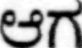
ಆಗ
